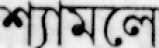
শ্যামলে
